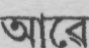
আৱে
